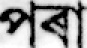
পৰা
